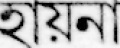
হায়না
